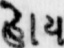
હોય
